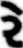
રે
